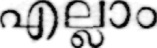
എല്ലാം
